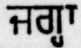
ਜਗ੍ਹਾ
